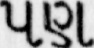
પણ
